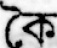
কৈ
